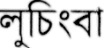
লুচিংবা
